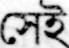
সেই
